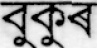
বুকুৰ
